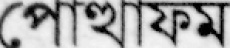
পোত্থাফম
